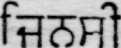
ਜਿਨਸੀ
